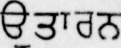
ਉਤਾਰਨ
